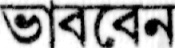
ভাববেন
